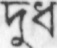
দুধ
